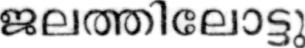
ജലത്തിലോട്ടു
